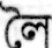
লৈ
